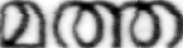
മത്ത
